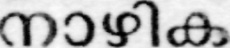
നാഴിക
